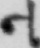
ન
